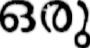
ഒരു
